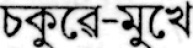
চকুৱে-মুখে
